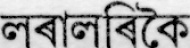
লৰালৰিকৈ
